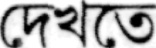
দেখতে
